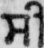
ਸੀ
